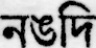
নঙদি
